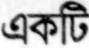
একটি
